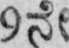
9ನೇ
